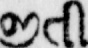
જીતી
